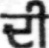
ਦੀ
